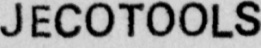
JECOTOOLS
